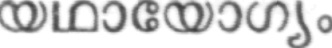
യഥായോഗ്യം
